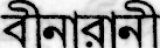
বীনারানী
